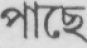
পাছে
